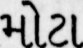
મોટા
